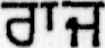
ਰਾਜ
